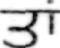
ਤਾਂ
